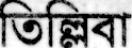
তিল্লিবা
